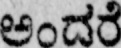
ಅಂದರೆ
